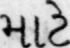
માટે
